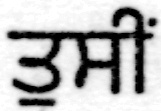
ਤੁਸੀਂ
